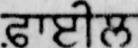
ਫ਼ਾਈਲ
